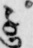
ઠું
